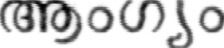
ആംഗ്യം
